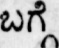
ಬಗ್ಗೆ
